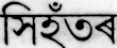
সিহঁতৰ
